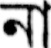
না
